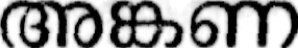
അങ്കണ
